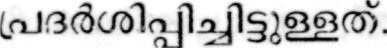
പ്രദര്‍ശിപ്പിച്ചിട്ടുള്ളത്.
